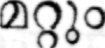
മറ്റും
